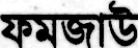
ফমজাউ
